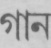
গান
